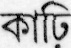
কাঢ়ি
